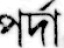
পর্দা
